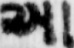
આ
